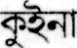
কুইনা
